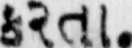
કરતા.
